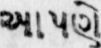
આપણે
